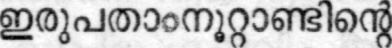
ഇരുപതാംനൂറ്റാണ്ടിന്റെ
